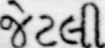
જેટલી
